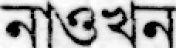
নাওখন
